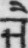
ਜੈ
